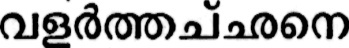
വളര്‍ത്തച്ഛനെ
